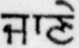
ਜਾਣੇ
